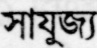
সাযুজ্য
